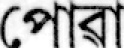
পোৱা
